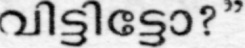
വിട്ടിട്ടോ?''
